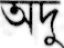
অদু
